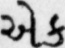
એક
